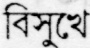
বিসুখে
